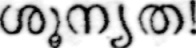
ശൂന്യത!
